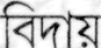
বিদায়
